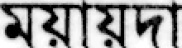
ময়ায়দা
